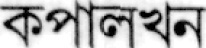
কপালখন
